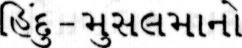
હિંદુ-મુસલમાનો
